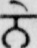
ਨੇ
